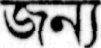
জন্য
